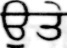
ਉਤੇ
